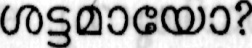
ശട്ടമായോ?
